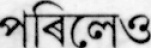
পৰিলেও
